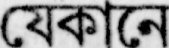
যেকানে
